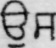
ਉਸ
